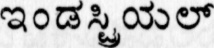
ಇಂಡಸ್ಟ್ರಿಯಲ್
